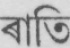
ৰাতি
